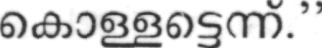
കൊള്ളട്ടെന്ന്."
